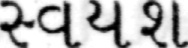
સ્વયશ
